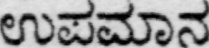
ಉಪಮಾನ
